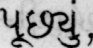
પૂછ્યું,
